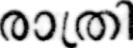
രാത്രി
